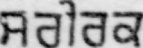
ਸਰੀਰਕ
